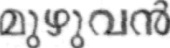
മുഴുവന്‍
